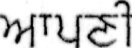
ਆਪਣੀ
